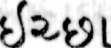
ઇચ્છા
